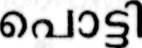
പൊട്ടി
